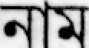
নাম
